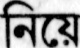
নিয়ে
